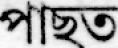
পাছত
